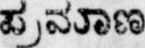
ಪ್ರಮಾಣ
